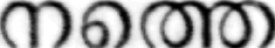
നത്തെ
